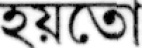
হয়তো
